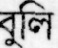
বুলি
